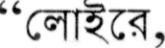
“লোইরে,
